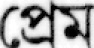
প্রেম
